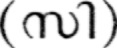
(സി)
